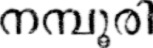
നമ്പൂരി
